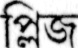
প্লিজ
